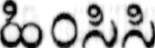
ಹಿಂಸಿಸಿ
